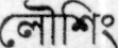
লৌশিং
